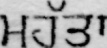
ਮਹੱਤਾ
